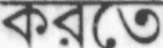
করতে
